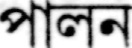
পালন
